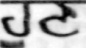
ਹੁਣ
